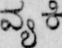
ವ್ಯಕಿ
